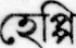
হেপ্পি
